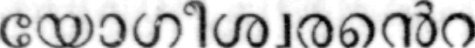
യോഗീശ്വരന്റെ
